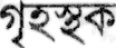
গৃহস্থক
